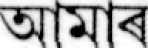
আমাৰ
